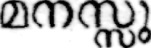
മനസ്സു
